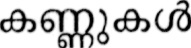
കണ്ണുകള്‍
